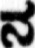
ನ
